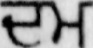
ਦਮ
